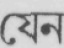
যেন
